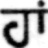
ਹਾਂ
